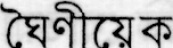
ঘৈণীয়েক
